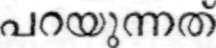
പറയുന്നത്
